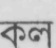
কল
